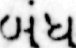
બંધ
